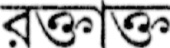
রক্তাক্ত
